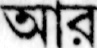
আর
